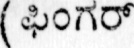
(ಫಿಂಗರ್
